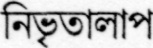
নিভৃতালাপ
